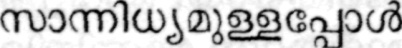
സാന്നിധ്യമുള്ളപ്പോള്‍
